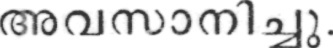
അവസാനിച്ചു.
